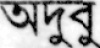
অদুবু
